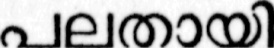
പലതായി
